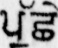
ਪੁੱਛੇ
